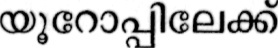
യൂറോപ്പിലേക്ക്
